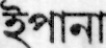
ইপানা
